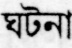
ঘটনা
